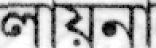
লায়না
